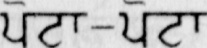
ਪੋਟਾ-ਪੋਟਾ
